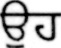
ਉਹ
